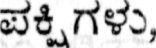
ಪಕ್ಷಿಗಳು,
